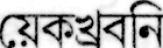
য়েকখ্রবনি
